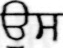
ਉਸ
